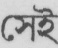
সেই
